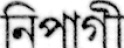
নিপাগী
